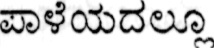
ಪಾಳೆಯದಲ್ಲೂ
